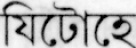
যিটোহে
